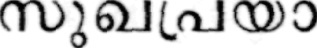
സുഖപ്രയാ
